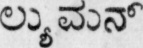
ಲ್ಯುಮನ್
